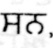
ਸਨ,
